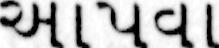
આપવા
